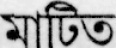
মাটিত
